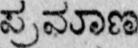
ಪ್ರಮಾಣ
